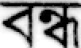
বন্ধ
